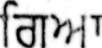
ਗਿਆ
